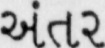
અંતર
